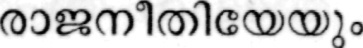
രാജനീതിയേയും
